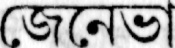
জেনেভা
